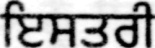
ਇਸਤਰੀ
